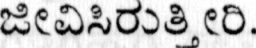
ಜೀವಿಸಿರುತ್ತೀರಿ.
